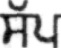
ਸੱਪ
